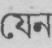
যেন
